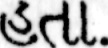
હતા.
